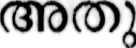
അതു
